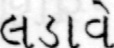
લડાવે
